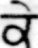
ਕੇ
